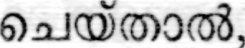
ചെയ്താല്‍,
